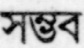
সম্ভব
